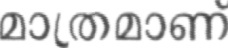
മാത്രമാണ്
